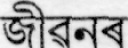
জীৱনৰ
